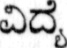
ವಿದ್ಯೆ
